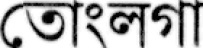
তোংলগা
